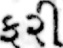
ફરી
